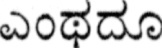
ಎಂಥದೂ
